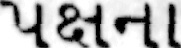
પક્ષના
